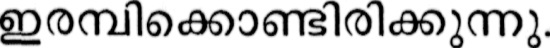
ഇരമ്പിക്കൊണ്ടിരിക്കുന്നു.
